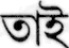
তাই
